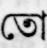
তো
